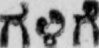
ಗಳಿಗೆ
